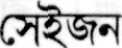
সেইজন
